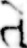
તે
